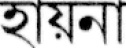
হায়না
